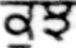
ਕੁਝ
